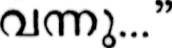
വന്നു...”
